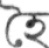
হৈ
